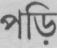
পড়ি
